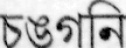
চঙগনি
